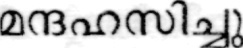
മന്ദഹസിച്ചു
